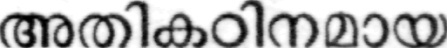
അതികഠിനമായ
